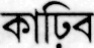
কাঢ়িব
